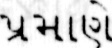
પ્રમાણે
